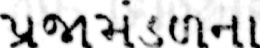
પ્રજામંડળના
